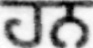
ਹਨ
